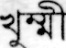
খুম্মী
